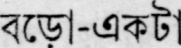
বড়ো-একটা
